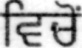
ਵਿਚੋਂ
